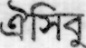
ঐসিবু
